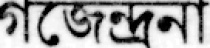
গজেন্দ্রনা
